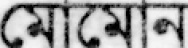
মোমোন
